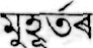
মুহূর্তৰ
